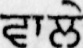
ਵਾਲੇ
